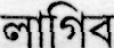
লাগিব
